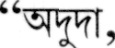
“অদুদা,
